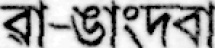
ৱা-ঙাংদবা
